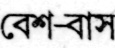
বেশ-বাস
